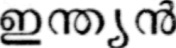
ഇന്ത്യന്‍
